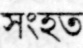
সংহত
